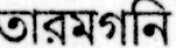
তারমগনি
